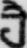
ਹੈ
